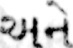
અને
